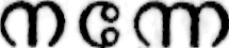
നന്നേ
